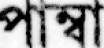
পাম্বা
